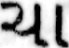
ચા
